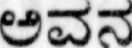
ಅವನ
